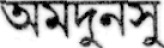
অমদুনসু
